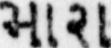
મારા
